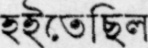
হইতেছিল
